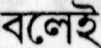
বলেই
